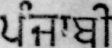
ਪੰਜਾਬੀ
